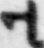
ન
